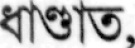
ধাণ্ডাত,
